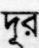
দূর
